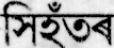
সিহঁতৰ
